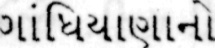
ગાંધિયાણાનો
